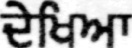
ਦੇਖਿਆ
